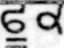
ਫੂਕ
